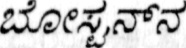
ಬೋಸ್ಟನ್‌ನ
